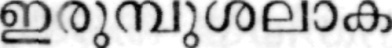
ഇരുമ്പുശലാക
